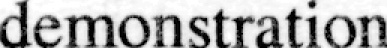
demonstration
